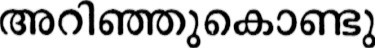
അറിഞ്ഞുകൊണ്ടു
